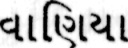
વાણિયા
